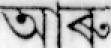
আৰু
